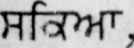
ਸਕਿਆ,
